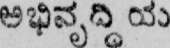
ಅಭಿವೃದ್ಧಿಯ
